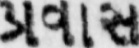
પ્રવાસ
